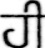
ਹੀ
